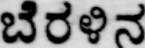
ಬೆರಳಿನ
